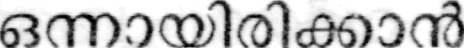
ഒന്നായിരിക്കാന്‍
